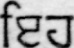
ਇਹ
